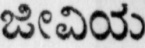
ಜೀವಿಯ
